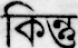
কিন্তু
